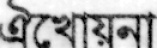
ঐখোয়না
